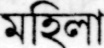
মহিলা
